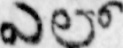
ಎಲ್
